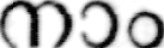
നാം
